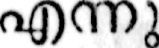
എന്നു
